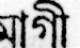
মাগী
